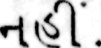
નહીં.
